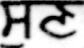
ਸੁਣ
